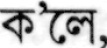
ক'লে,
